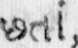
છતાં,
